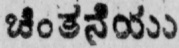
ಚಿಂತನೆಯು
